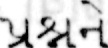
પ્રશ્નને
